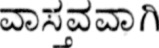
ವಾಸ್ತವವಾಗಿ
